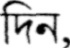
দিন,
